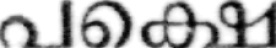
പക്ഷെ
